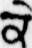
ਕੇ
